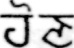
ਹੋਣ
